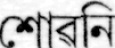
শোৱনি
